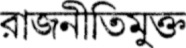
রাজনীতিমুক্ত
